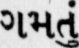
ગમતું
